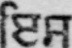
ਇਸ
